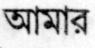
আমার
